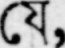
যে,
